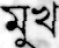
মুখ
